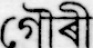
গৌৰী
